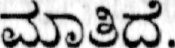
ಮಾತಿದೆ.
